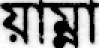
য়াম্না
